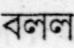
বলল
